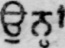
ਉਨ੍ਹਾਂ
